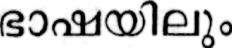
ഭാഷയിലും
